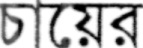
চায়ের
